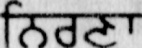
ਨਿਰਣਾ
